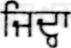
ਜਿਦ੍ਹਾ
